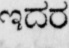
ಇದರ
